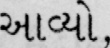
આવ્યો,
